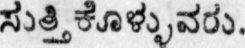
ಸುತ್ತಿಕೊಳ್ಳುವರು.
